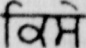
ਕਿਸੇ
